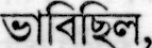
ভাবিছিল,
